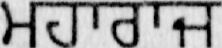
ਮਹਾਰਾਜ
